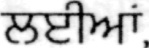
ਲਈਆਂ,
